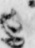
હું
